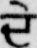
ਦੇ
